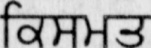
ਕਿਸਮਤ
